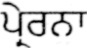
ਪ੍ਰੇਰਨਾ
